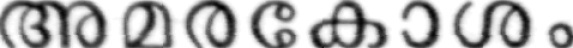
അമരകോശം
